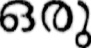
ഒരു
